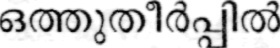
ഒത്തുതീര്‍പ്പില്‍
